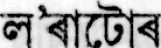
ল'ৰাটোৰ
